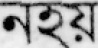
নহয়
